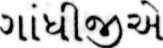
ગાંધીજીએ
